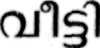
വീട്ടി
